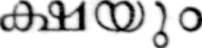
ക്ഷയും
